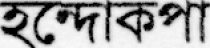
হন্দোকপা
